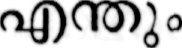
എന്തും
